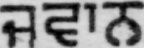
ਜਵਾਨ
